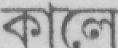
কালে
